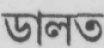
ডালত
